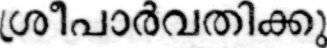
ശ്രീപാര്‍വതിക്കു
